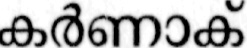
കര്‍ണാക്
